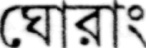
ঘোরাং
